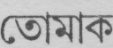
তোমাক
